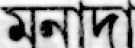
মনাদা
